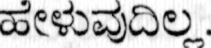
ಹೇಳುವುದಿಲ್ಲ.
